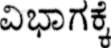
ವಿಭಾಗಕ್ಕೆ
